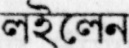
লইলেন
